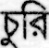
চুরি
